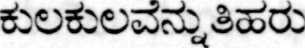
ಕುಲಕುಲವೆನ್ನುತಿಹರು
